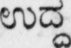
ಉದ್ದ
